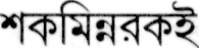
শকমিন্নরকই
